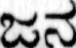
ಜನ
